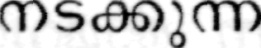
നടക്കുന്ന
